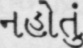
નહોતું
